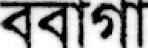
ববাগা
